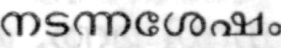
നടന്നശേഷം
